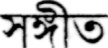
সঙ্গীত
